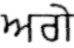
ਅਗੇ
